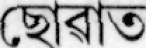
ছোৱাত
